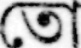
তো
